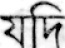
যদি
